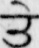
ਤੇ
